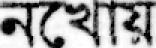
নখোয়
